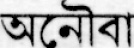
অনৌবা
